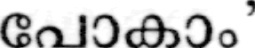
പോകാം’
